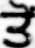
ਤੋਂ
